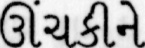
ઊંચકીને
